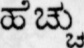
ಹೆಚ್ಚು
